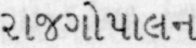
રાજગોપાલન
